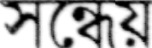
সন্ধেয়
